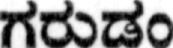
ಗರುಡ೦
